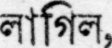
লাগিল,
